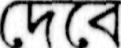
দেবে
